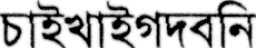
চাইখাইগদবনি
